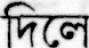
দিলে
